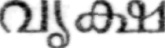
വൃക്ഷ
